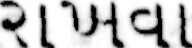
રાખવા
